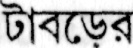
টাবড়ের
